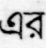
এর
